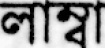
লাম্বা
